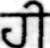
ਹੀ
